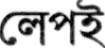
লেপই
